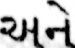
અને
